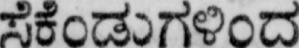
ಸೆಕೆಂಡುಗಳಿಂದ
